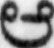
ಆ
